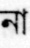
না
